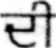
ਦੀ
